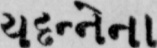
યદન્નેના
